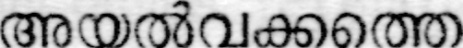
അയല്‍വക്കത്തെ
